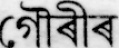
গৌৰীৰ
